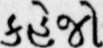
કહેજો
